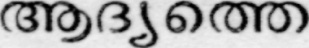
ആദ്യത്തെ
